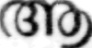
ആ
